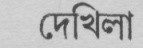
দেখিলা
